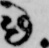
છે.
